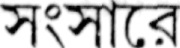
সংসারে
